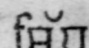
ਸਿੱਧਾ
